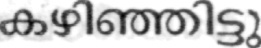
കഴിഞ്ഞിട്ടു
